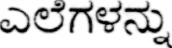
ಎಲೆಗಳನ್ನು
